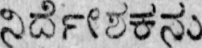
ನಿರ್ದೇಶಕನು
